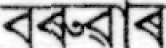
বৰুৱাৰ
